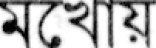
মখোয়
